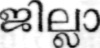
ജില്ലാ
